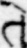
તે
